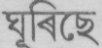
ঘূৰিছে
